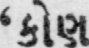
'કોણ
